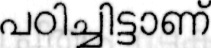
പഠിച്ചിട്ടാണ്
